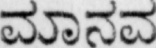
ಮಾನವ
